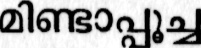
മിണ്ടാപ്പൂച്ച
